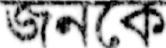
জনকে
